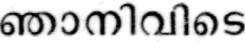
ഞാനിവിടെ
